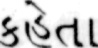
કહેતા
